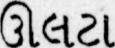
ઊલટા
